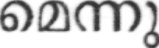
മെന്നു
